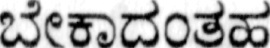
ಬೇಕಾದಂತಹ
